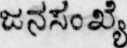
ಜನಸಂಖ್ಯೆ
